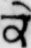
ਕੇ
